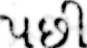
પછી
